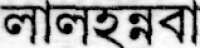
লালহন্নবা
